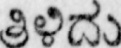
ತಿಳಿದು
